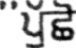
''ਪੁੱਛੋ
